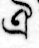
ঐ
